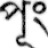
পূং
